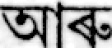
আৰু
